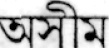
অসীম
